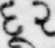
દૂર
